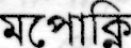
মপোক্নি
